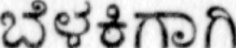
ಬೆಳಕಿಗಾಗಿ
